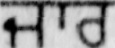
ਜਾਰ
